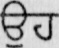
ਉਹ
